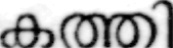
കത്തി
